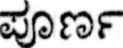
ಪೂರ್ಣ
